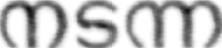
നടന്ന
